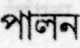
পালন
